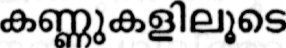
കണ്ണുകളിലൂടെ
